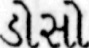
ડોસો
